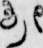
ಶ್ರೀ
